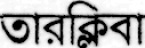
তারক্লিবা
